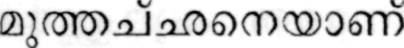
മുത്തച്ഛനെയാണ്
